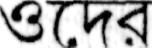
ওদের
